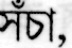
সঁচা,
